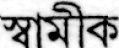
স্বামীক
